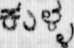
ಕುಳ್ಳ
